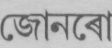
জোনৰো
